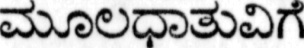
ಮೂಲಧಾತುವಿಗೆ
